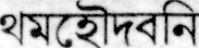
থমহৌদবনি
